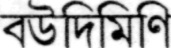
বউদিমিণি
